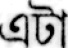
এটা
